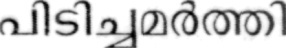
പിടിച്ചമര്‍ത്തി
